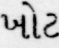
ખોટ
